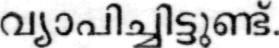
വ്യാപിച്ചിട്ടുണ്ട്.
